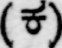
(ಕ)
